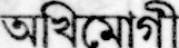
অখিমোগী
